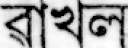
ৱাখল
